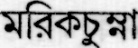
মরিকচুম্না
